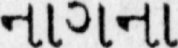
નાગના
